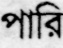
পারি
